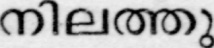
നിലത്തു
